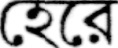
হেরে
